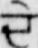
ਦੇ
